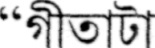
“গীতাটা
